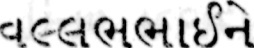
વલ્લભભાઈને
